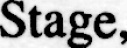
Stage,
